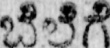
ಬೆಲೆಗೆ
